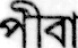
পীবা
